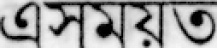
এসময়ত
